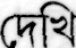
দেখি
